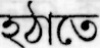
হঠাতে
